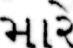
મારે
